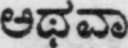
ಅಥವಾ
